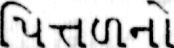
પિત્તળનો
